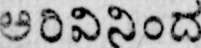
ಅರಿವಿನಿಂದ
